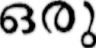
ഒരു
